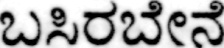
ಬಸಿರಬೇನೆ
